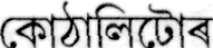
কোঠালিটোৰ
